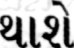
થાશે
